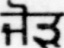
ਜੋੜ
